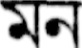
মন
